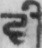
ਵੀ
